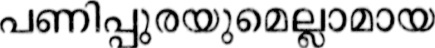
പണിപ്പുരയുമെല്ലാമായ
